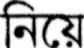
নিয়ে
